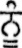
ਨੂੰ
